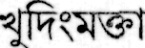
খুদিংমক্তা
